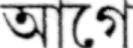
আগে
